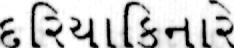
દરિયાકિનારે
